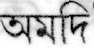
অমদি
